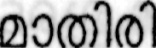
മാതിരി
